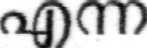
എന്ന
